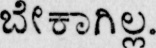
ಬೇಕಾಗಿಲ್ಲ.
